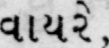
વાયરે,
